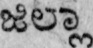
ಜಿಲ್ಲಾ
